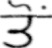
ਤੋਂ
